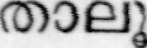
താലൂ
